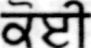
ਕੋਈ
